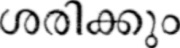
ശരിക്കും
